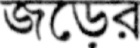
জড়ের
